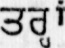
ਤਰ੍ਹਾਂ
